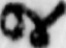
જ
